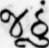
જૂઠું
